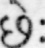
છેઃ
